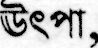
ঊৎপা,
